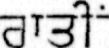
ਰਾਤੀਂ
